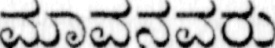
ಮಾವನವರು
